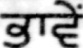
ਭਾਵੇਂ
